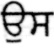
ਉਸ
